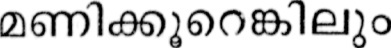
മണിക്കൂറെങ്കിലും
